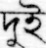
দুই
